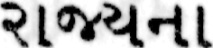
રાજ્યના
